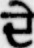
ਦੇ
